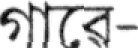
গাৱে-
